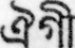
ঐগী
